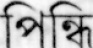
পিন্ধি
